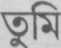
তুমি
